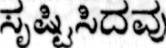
ಸೃಷ್ಟಿಸಿದವು
